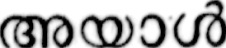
അയാള്‍
